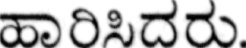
ಹಾರಿಸಿದರು.
